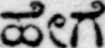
ಹೇಗೆ
